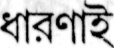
ধারণাই
